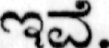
ಇವೆ.
